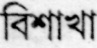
বিশাখা
